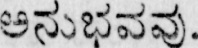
ಅನುಭವವು.
